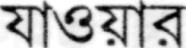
যাওয়ার
